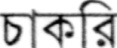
চাকরি
